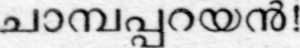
ചാമ്പപ്പറയന്‍!
